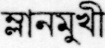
ম্লানমুখী
